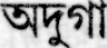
অদুগা
